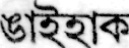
ঙাইহাক
